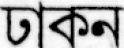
ঢাকন
